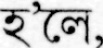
হ'লে,
